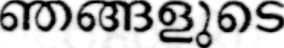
ഞങ്ങളുടെ
